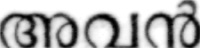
അവന്‍
